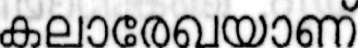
കലാരേഖയാണ്
